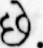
છે.
